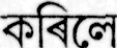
কৰিলে
